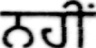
ਨਹੀਂ
